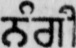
ਨੰਗੀ
